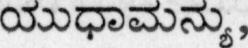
ಯುಧಾಮನ್ಯು,
